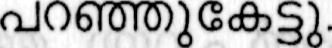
പറഞ്ഞുകേട്ടു.
